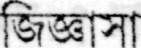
জিজ্ঞাসা
